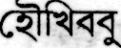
হৌখিববু
